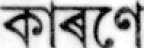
কাৰণে
